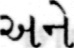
અને
